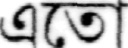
এতো
